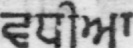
ਵਧੀਆ
